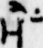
ਮੈਂ
